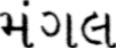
મંગલ
